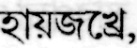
হায়জখ্রে,
